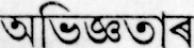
অভিজ্ঞতাৰ
